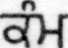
ਕੰਮ
